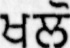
ਖਲੋ
